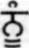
ਨੂੰ
